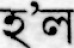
হ'ল
